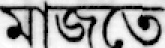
মাজতে
